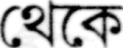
থেকে
